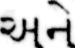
અને
